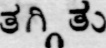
ತಗ್ಗಿತು
